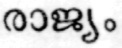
രാജ്യം
